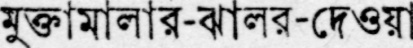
মুক্তামালার-ঝালর-দেওয়া
